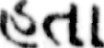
હતા
